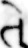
તે
